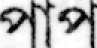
পাপ
